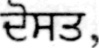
ਦੋਸਤ,
